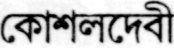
কোশলদেবী
